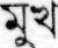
মুখ
